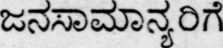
ಜನಸಾಮಾನ್ಯರಿಗೆ
